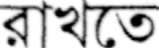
রাখতে
